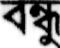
বন্ধু
